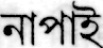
নাপাই
